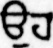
ਉਹ
